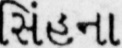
સિંહના
